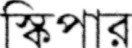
স্কিপার
